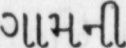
ગામની
